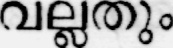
വല്ലതും
